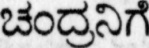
ಚಂದ್ರನಿಗೆ
